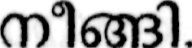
നീങ്ങി.
